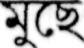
মুছে
